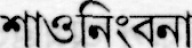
শাওনিংবনা
